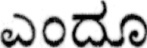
ಎಂದೂ
